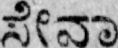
ಸೇವಾ
